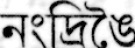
নংদ্রিঙৈ
